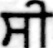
ਸੀ
